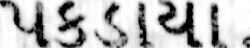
પકડાયા.
